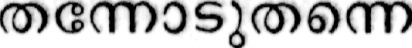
തന്നോടുതന്നെ
